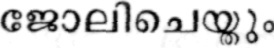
ജോലിചെയ്തും
